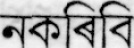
নকৰিবি
